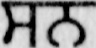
ਸਨ
